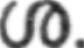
ശ.
